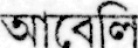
আবেলি
